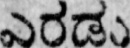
ಎರಡು
